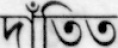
দাঁতিত
